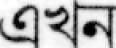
এখন
